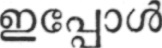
ഇപ്പോള്‍
